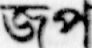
জপ
